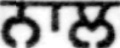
ਨਾਲ
